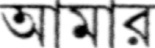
আমার
